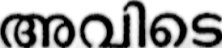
അവിടെ
